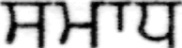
ਸਮਾਧ
